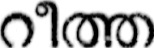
റീത്ത
